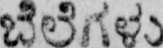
ಬೆಲೆಗಳು
